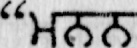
''ਮਨਨ
